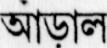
আড়াল
